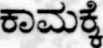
ಕಾಮಕ್ಕೆ
